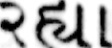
રહ્યા
